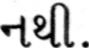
નથી.
